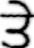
ਤੇ
